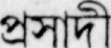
প্রসাদী
